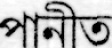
পানীত
